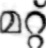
മറ്റ്
